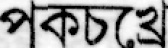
পকচখ্রে
